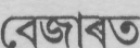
বেজাৰত
